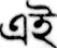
এই
